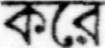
করে
